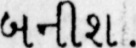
બનીશ.
